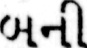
બની
